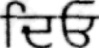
ਦਿਓ
